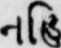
નહિ
